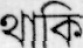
থাকি
